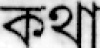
কথা
